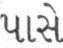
પાસે
